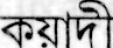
কয়াদী
